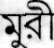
মুরী
